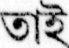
তাই
